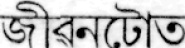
জীৱনটোত
